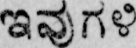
ಇವುಗಳಿ
